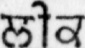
ਲੀਕ
